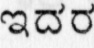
ಇದರ
